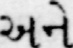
અને
